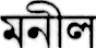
মনীল
